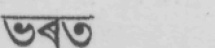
ভৰত
